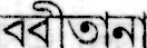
ববীতানা
